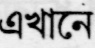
এখানে
